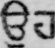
ਉਹ
